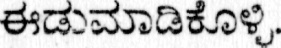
ಈಡುಮಾಡಿಕೊಳ್ಳಿ.
